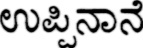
ಉಪ್ಪಿನಾನೆ
